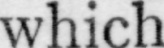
which
